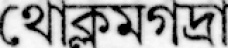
থোক্লমগদ্রা
